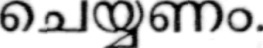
ചെയ്യണം.
